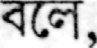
বলে,
